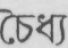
চৈধ্য
